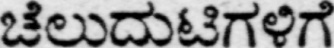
ಚೆಲುದುಟಿಗಳಿಗೆ
